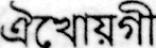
ঐখোয়গী
